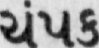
ચંપક
